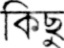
কিছু
